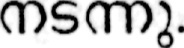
നടന്നു.
